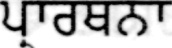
ਪ੍ਰਾਰਥਨਾ
